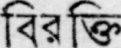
বিরক্তি
